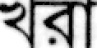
খরা
